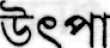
উৎপা
